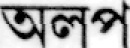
অলপ
